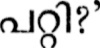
പറ്റി?'
